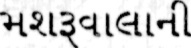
મશરૂવાલાની
